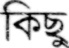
কিছু
